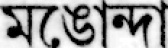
মঙোন্দা
